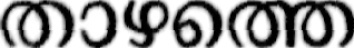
താഴത്തെ
